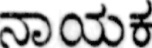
ನಾಯಕ
